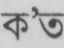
ক'ত
